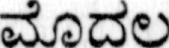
ಮೊದಲ
